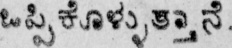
ಒಪ್ಪಿಕೊಳ್ಳುತ್ತಾನೆ.
